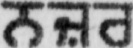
ਨਜ਼ਰ
